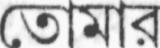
তোমার
